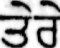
ਤੇਰੇ
